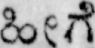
ಹೀಗೆ
